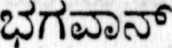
ಭಗವಾನ್
